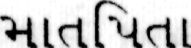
માતાપિતા
